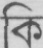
কি
